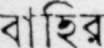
বাহির
